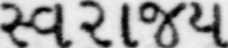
સ્વરાજ્ય
